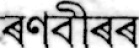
ৰণবীৰৰ
